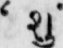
'શું
